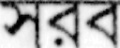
সরব
